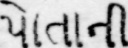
પોતાની
